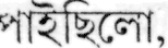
পাইছিলো,
